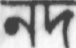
নদ
